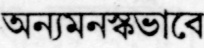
অন্যমনস্কভাবে
